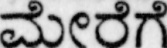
ಮೇರೆಗೆ
